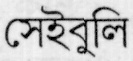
সেইবুলি
